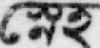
স্নেহ
